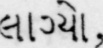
લાગ્યો,
